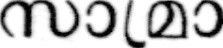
സാമ്രാ
